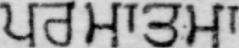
ਪਰਮਾਤਮਾ
